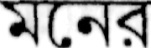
মনের
